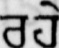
ਰਹੇ
